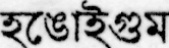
হঙোইগুম
